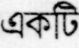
একটি
